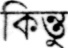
কিন্তু
